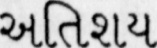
અતિશય
